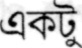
একটু
